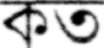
কত
